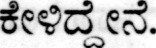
ಕೇಳಿದ್ದೇನೆ.
